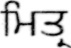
ਮਿਤ੍ਰ
